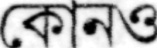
কোনও
